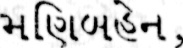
મણિબહેન,
